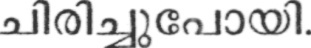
ചിരിച്ചുപോയി.
